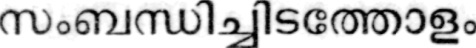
സംബന്ധിച്ചിടത്തോളം
